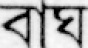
বাঘ
